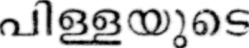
പിള്ളയുടെ
